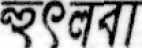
হুৎনবা
